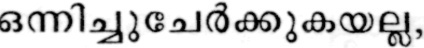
ഒന്നിച്ചുചേര്‍ക്കുകയല്ല,
